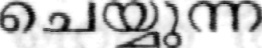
ചെയ്യുന്ന
